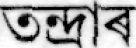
তন্দ্রাৰ
